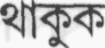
থাকুক
